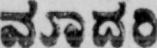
ಮಾದರಿ
